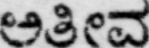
ಅತೀವ
